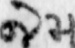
જેમ
